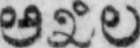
ಅಖಿಲ
